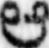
ಆ
